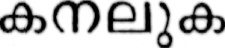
കനലുക
